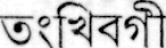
তংখিবগী
